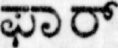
ಫಾರ್
